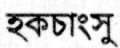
হকচাংসু
